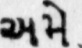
અમે
